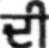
ਦੀ
